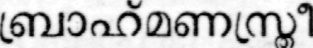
ബ്രാഹ്മണസ്ത്രീ
